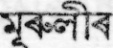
মূৰুলীৰ
